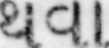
થવા
